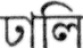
ঢালি
